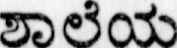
ಶಾಲೆಯ
